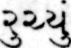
રુચ્યું
